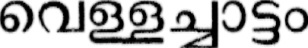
വെള്ളച്ചാട്ടം
